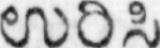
ಉರಿಸಿ
